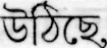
উঠিছে,
